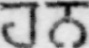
ਹਨ
